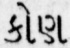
કોણ
